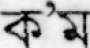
ক'ম
